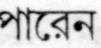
পারেন
